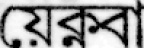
য়েক্নবা
